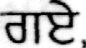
ਗਏ,
